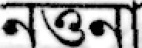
নত্তনা
